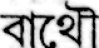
বাথৌ
